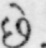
છે.
